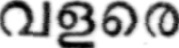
വളരെ
